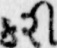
કરી
